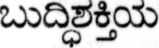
ಬುದ್ಧಿಶಕ್ತಿಯ
